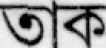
তাক
